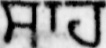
ਸਾਹ
